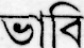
ভাবি
